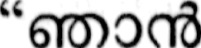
“ഞാന്‍
